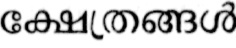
ക്ഷേത്രങ്ങള്‍
